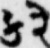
કરે
